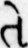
તે
